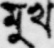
মুখ
